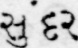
સુંદર
